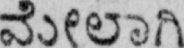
ಮೇಲಾಗಿ
